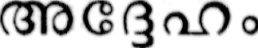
അദ്ദേഹം
